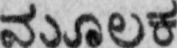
ಮೂಲಕ
